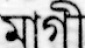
মাগী
